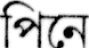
পিনে
